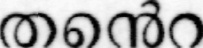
തന്റെ
